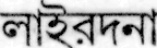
লাইরদনা
